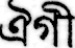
ঐগী
